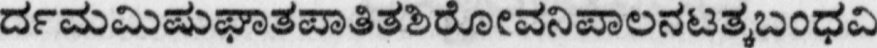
ರ್ದಮಮಿಷುಘಾತಪಾತಿತಶಿರೋವನಿಪಾಲನಟತ್ಕಬಂಧವಿ
